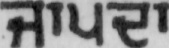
ਜਾਪਦਾ
